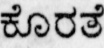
ಕೊರತೆ
